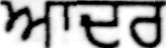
ਆਦਰ
